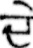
ਦੇ
